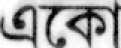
একো
